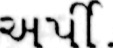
અર્પી.
